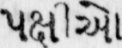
પક્ષીઓ
